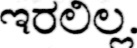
ಇರಲಿಲ್ಲ.
